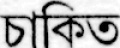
চাকিত
